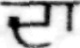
ਦਾ
